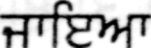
ਜਾਇਆ
